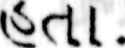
હતા.
